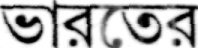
ভারতের
